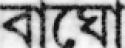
বাঘো
